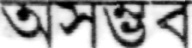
অসম্ভব
